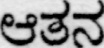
ಆತನ
